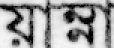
য়াম্না
